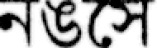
নঙসে
